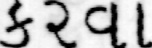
કરવા
